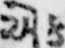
એક
